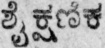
ಶೈಕ್ಷಣಿಕ
